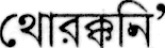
থোরক্কনি’
